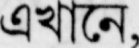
এখানে,
